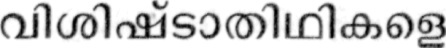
വിശിഷ്ടാതിഥികളെ
